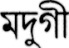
মদুগী
